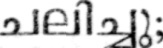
ചലിച്ചു;
